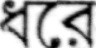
ধরে
